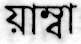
য়াম্বা
